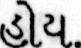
હોય.
